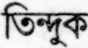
তিন্দুক
